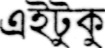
এইটুকু
